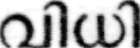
വിധി
